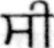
ਸੀ
